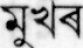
মুখৰ
